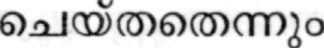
ചെയ്തതെന്നും
